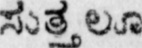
ಸುತ್ತಲೂ
